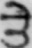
ਤੇ
